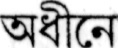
অধীনে
